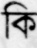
কি
